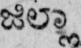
ಜಿಲ್ಲಾ
